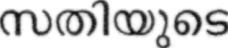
സതിയുടെ
